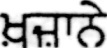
ਖ਼ਜ਼ਾਨੇ
